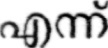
എന്ന്
